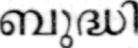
ബുദ്ധി
